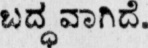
ಬದ್ಧವಾಗಿದೆ.
